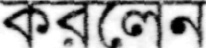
করলেন
